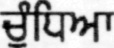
ਚੁੰਧਿਆ
